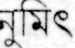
নুমিৎ
